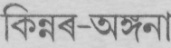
কিন্নৰ-অঙ্গনা
